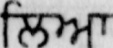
ਲਿਆ
